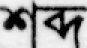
শব্দ
